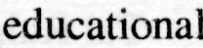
educational
